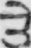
ਤੇ
